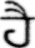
ਹੈ
